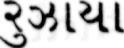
રુઝાયા
